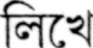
লিখে
